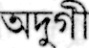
অদুগী
